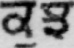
ਕੁਝ
